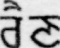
ਰੈਣ
